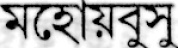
মহোয়বুসু
